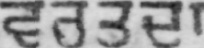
ਵਰਤਦਾ
